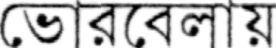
ভোরবেলায়
